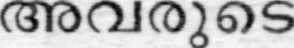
അവരുടെ
